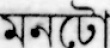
মনটো
